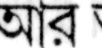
আর
